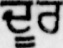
ਦੂਰ
